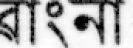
ৱাংনা
